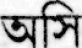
অসি
